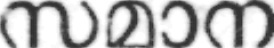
സമാന
